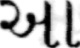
આ
